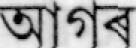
আগৰ
